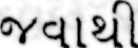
જવાથી
